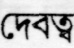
দেবত্ব
